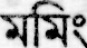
মমিং
